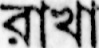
রাখা
